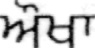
ਔਖਾ
